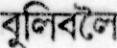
বুলিবলৈ
